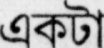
একটা
